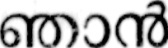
ഞാന്‍
